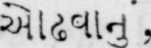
ઓઢવાનું,
